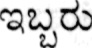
ಇಬ್ಬರು
